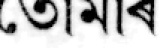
তোমাৰ
